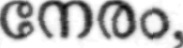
നേരം,
